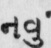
નવું
